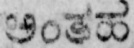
ಅಂತಹ
